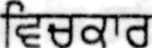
ਵਿਚਕਾਰ
